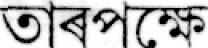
তাৰপক্ষে
